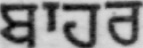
ਬਾਹਰ
